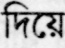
দিয়ে
